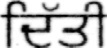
ਦਿੱਤੀ
